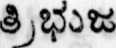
ತ್ರಿಭುಜ
